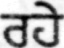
ਰਹੇ
